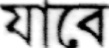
যাবে
